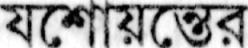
যশোয়ন্তের
